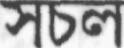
সচল
